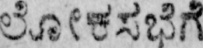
ಲೋಕಸಭೆಗೆ
